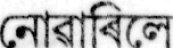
নোৱাৰিলে
